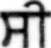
ਸੀ
